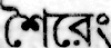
শৈরেং
